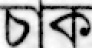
চাক
